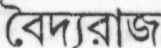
বৈদ্যরাজ
